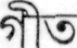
গীত
